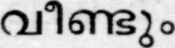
വീണ്ടും
